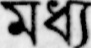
মধ্য
